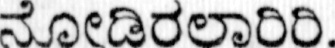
ನೋಡಿರಲಾರಿರಿ.
